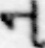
ન
